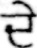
ਦੇ
